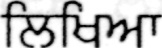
ਲਿਖਿਆ
